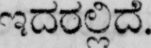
ಇದರಲ್ಲಿದೆ.
